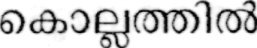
കൊല്ലത്തില്‍
